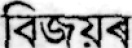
বিজয়ৰ
